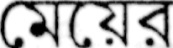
মেয়ের
